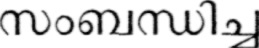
സംബന്ധിച്ച
